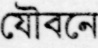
যৌবনে
